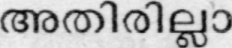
അതിരില്ലാ
